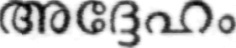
അദ്ദേഹം
